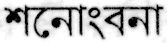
শনোংবাবু
